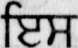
ਇਸ
